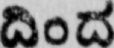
ದಿಂದ
